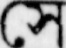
সে
